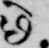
છે.
